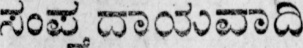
ಸಂಪ್ತದಾಯವಾದಿ
